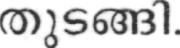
തുടങ്ങി.
